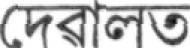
দেৱালত
